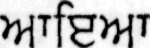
ਆਇਆ
